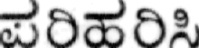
ಪರಿಹರಿಸಿ
